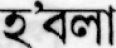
হ'বলা
